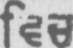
ਵਿਚ
